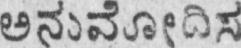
ಅನುಮೋದಿಸ
